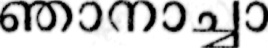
ഞാനാച്ചാ
